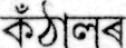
কঁঠালৰ
